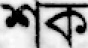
শক
